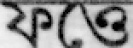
ফত্তে
